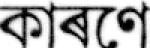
কাৰণে
